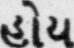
હોય
